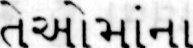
તેઓમાંના
